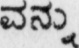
ವನ್ನು
